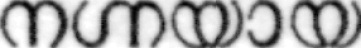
നഗ്നയായ
